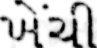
ખેંચી
